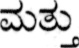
ಮತ್ತು
